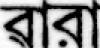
ৱারা
